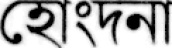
হোংদনা
